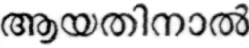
ആയതിനാല്‍
